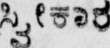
ಸ್ವೀಕಾರ
